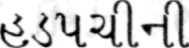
હડપચીની
